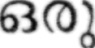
ഒരു
